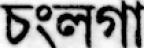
চংলগা
